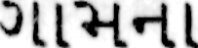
ગામના
